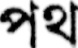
পথ
